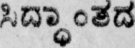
ಸಿದ್ಧಾಂತದ
